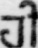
ਹੀ
